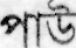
পাউ
